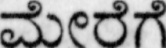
ಮೇರೆಗೆ
